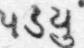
પડ્યું
